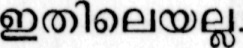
ഇതിലെയല്ല.
